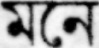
মনে
